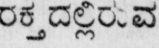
ರಕ್ತದಲ್ಲಿರುವ
